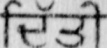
ਦਿੱਤੀ
